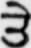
ਤੇ
